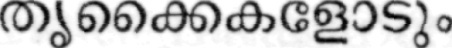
തൃക്കൈകളോടും
